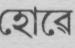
হোৱে
